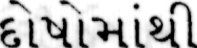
દોષોમાંથી
